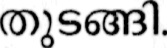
തുടങ്ങി.
